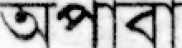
অপাবা
